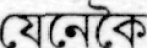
যেনেকৈ
